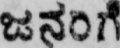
ಜನರಿಗೆ
